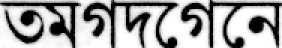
তমগদগেনে
